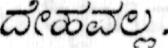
ದೇಹವಲ್ಲ.
